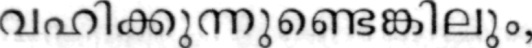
വഹിക്കുന്നുണ്ടെങ്കിലും,
